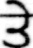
ਤੇ
